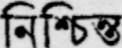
নিশ্চিন্ত
